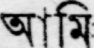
আমি
